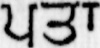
ਪਤਾ
